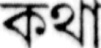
কথা
